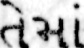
તેમાં
